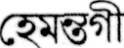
হেমন্তগী
